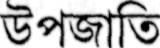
উপজাতি
